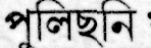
পুলিছনি
